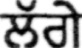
ਲੱਗੇ
